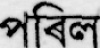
পৰিল
